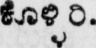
ಕೊಳ್ಳಿರಿ.
